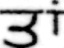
ਤਾਂ
